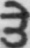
ਤੇ
